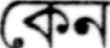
কেন
